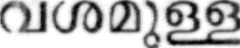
വശമുള്ള
